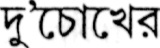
দু’চোখের
